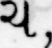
ચ,
